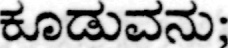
ಕೂಡುವನು;
